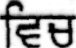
ਵਿਚ
